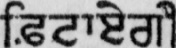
ਫ਼ਿਟਾਏਗੀ
